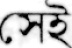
সেই
